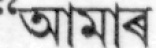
"আমাৰ
